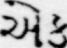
એક
